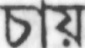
চায়
